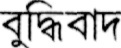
বুদ্ধিবাদ
